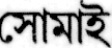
সোমাই
